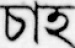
চাহ
